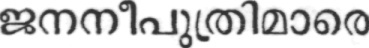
ജനനീപുത്രിമാരെ
